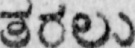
ತರಲು
